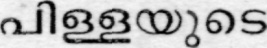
പിള്ളയുടെ
